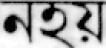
নহয়
